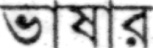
ভাষার
